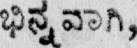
ಭಿನ್ನವಾಗಿ,
